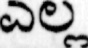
ಎಲ್ಲ
